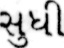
સુધી
